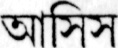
আসিস
